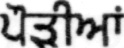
ਪੌੜੀਆਂ
